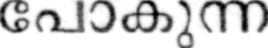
പോകുന്ന
